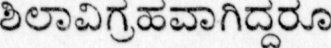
ಶಿಲಾವಿಗ್ರಹವಾಗಿದ್ದರೂ
